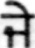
ਜੇ
